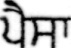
ਪੈਸਾ
